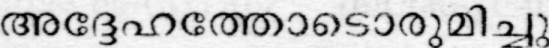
അദ്ദേഹത്തോടൊരുമിച്ചു
